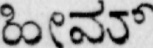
ಹೀಮ್
